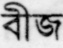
বীজ
